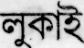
লুকাই
